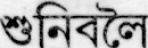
শুনিবলৈ
